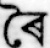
ৰৈ
